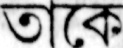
তাকে
